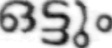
ഒട്ടും
